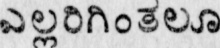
ಎಲ್ಲರಿಗಿಂತಲೂ
